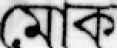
মোক
